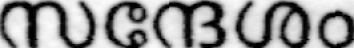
സന്ദേശം
